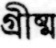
গ্রীষ্ম
